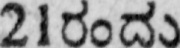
21ರಂದು
